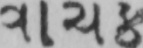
વાચક
